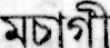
মচাগী
